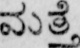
ಮತ್ತೆ
